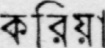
করিয়া
